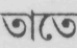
তাতে
